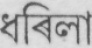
ধৰিলা
